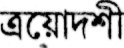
ত্রয়োদশী
